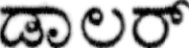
ಡಾಲರ್
